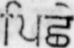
ਪਿਛੇ
